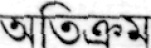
অতিক্রম
